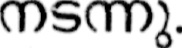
നടന്നു.
